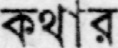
কথার
